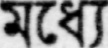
মধ্যে
